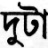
দুটা
